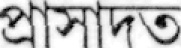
প্রাসাদত
